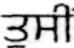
ਤੁਸੀਂ
